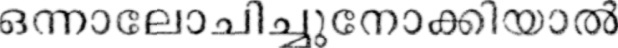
ഒന്നാലോചിച്ചുനോക്കിയാല്‍
